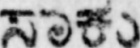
ಸಾಕು
